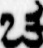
ಚ
